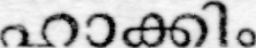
ഹാക്കിം
